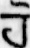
ਹੋ
